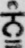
ਨੂੰ
